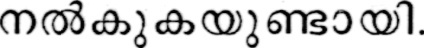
നല്‍കുകയുണ്ടായി.
